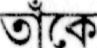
তাঁকে
